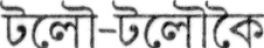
টলৌ-টলৌকৈ
